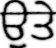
ਉਤੇ
